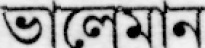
ভালেমান
